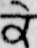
ਕੇ
